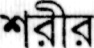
শরীর
